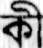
কী
